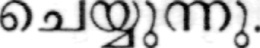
ചെയ്യുന്നു.
